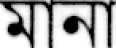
মানা
